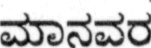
ಮಾನವರ
